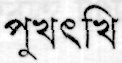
পুখৎখি
